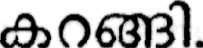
കറങ്ങി.
